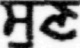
ਸੁਣ
